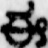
ಈ
